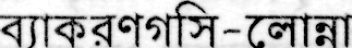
ব্যাকরণগসি-লোন্না
